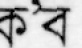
ক'ব
